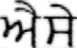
ਐਸੇ
